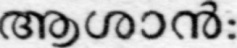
ആശാന്‍:
